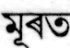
মূৰত
